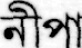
নীপা
